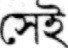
সেই
